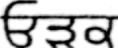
ਓੜਕ
